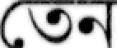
তেন
